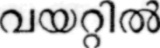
വയറ്റില്‍
